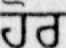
ਹੋਰ
